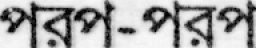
পরপ-পরপ
